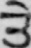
ਤੇ
